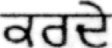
ਕਰਦੇ
